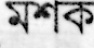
মশক
